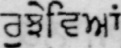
ਰੁਝੇਵਿਆਂ
